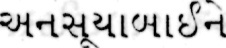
અનસૂયાબાઈને
